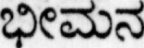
ಭೀಮನ
